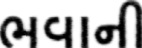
ભવાની
